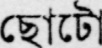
ছোটো
